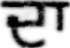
ਦਾ
